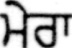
ਮੇਰਾ
